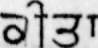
ਕੀਤਾ
